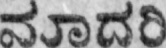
ಮಾದರಿ
